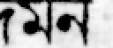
দমন
